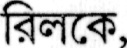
রিলকে,
